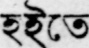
হইতে
